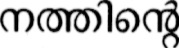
നത്തിന്റെ
